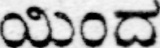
ಯಿಂದ
